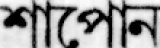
শাপোন
